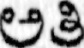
ಅತಿ
